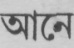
আনে
